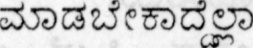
ಮಾಡಬೇಕಾದ್ದೆಲ್ಲಾ
